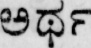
ಅರ್ಥ
